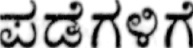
ಪಡೆಗಳಿಗೆ
